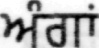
ਅੰਗਾਂ
